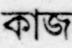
কাজ
